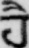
ਹੈ
